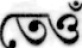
তেওঁ
